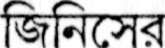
জিনিসের
